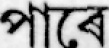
পাৰে
